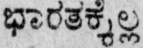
ಭಾರತಕ್ಕೆಲ್ಲ
